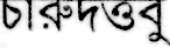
চারুদত্তবু
